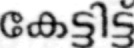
കേട്ടിട്ട്
